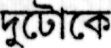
দুটোকে
